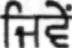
ਜਿਵੇਂ
